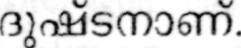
ദുഷ്ടനാണ്.
